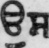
ਉਸ
